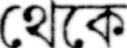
থেকে
